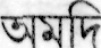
অমদি
